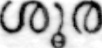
ശൂര
